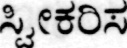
ಸ್ವೀಕರಿಸ
